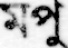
মপু
